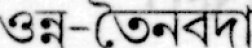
ওন্ন-তৈনবদা
